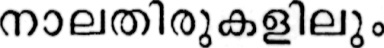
നാലതിരുകളിലും
